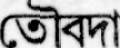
তৌবদা
